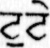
ਟੁਟੇ
